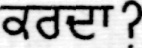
ਕਰਦਾ?
